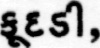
ફૂદડી,
